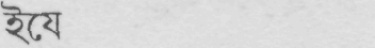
ইযে
